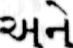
અને
